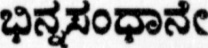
ಭಿನ್ನಸಂಧಾನೇ
